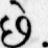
છે.
